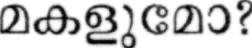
മകളുമോ?
